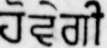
ਹੋਵੇਗੀ
